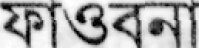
ফাওবনা
